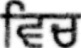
ਵਿਚ
